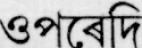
ওপৰেদি
